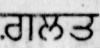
ਗ਼ਲਤ
